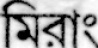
মিরাং
